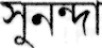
সুনন্দা
